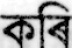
কৰি
